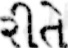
રીતે
